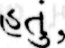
હતું,
